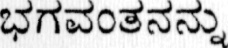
ಭಗವಂತನನ್ನು
